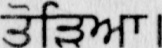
ਤੋੜਿਆ।
